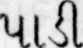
પાડી
